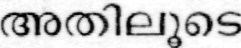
അതിലൂടെ
